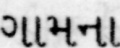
ગામના
